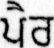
ਪੈਰ
